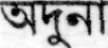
অদুনা
